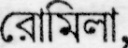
রোমিলা,
